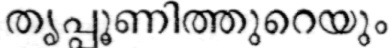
തൃപ്പൂണിത്തുറെയും
